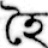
হৈ
